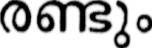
രണ്ടും
